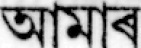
আমাৰ
